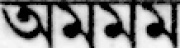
অমমম
